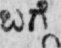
ಬಗ್ಗೆ
